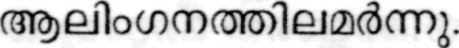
ആലിംഗനത്തിലമര്‍ന്നു.
